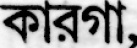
কারগা,
